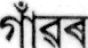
গাঁৱৰ
